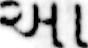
આ
